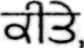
ਕੀਤੇ,
